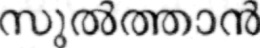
സുല്‍ത്താന്‍
